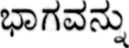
ಭಾಗವನ್ನು
